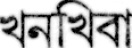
খনখিবা
